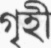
গৃহী
